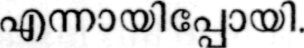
എന്നായിപ്പോയി.
